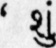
'શું
